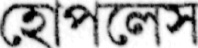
হোপলেস
